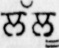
ਲੱਲੂ
